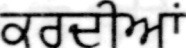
ਕਰਦੀਆਂ
